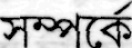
সম্পর্কে
